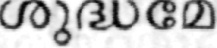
ശുദ്ധമേ
